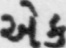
એક
